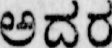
ಅದರ
